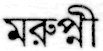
মরুপ্নী
